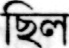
ছিল
